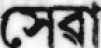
সেৱা
